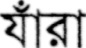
যাঁরা
